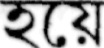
হয়ে
